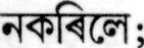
নকৰিলে;
